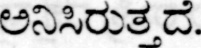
ಅನಿಸಿರುತ್ತದೆ.
